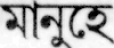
মানুহে
